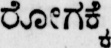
ರೋಗಕ್ಕೆ
